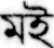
মই
